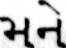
મને
